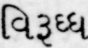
વિરૂધ્ધ
